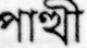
পাত্থী
